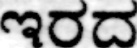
ಇರದ
